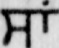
ਸਾਂ
